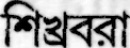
শিখ্রবরা
